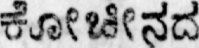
ಕೋಚೀನದ
